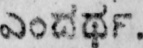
ಎಂದರ್ಥ,
